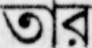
তার
